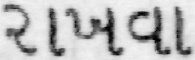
રાખવા
